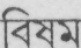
বিষম
